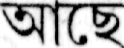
আছে
